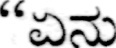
"ಏನು
